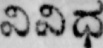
ವಿವಿದ
